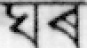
ঘৰ
